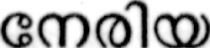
നേരിയ
